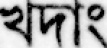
খদাং
